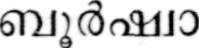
ബൂര്‍ഷ്വാ
